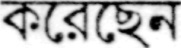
করেছেন
